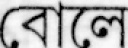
বোলে
